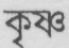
কৃষ্ণ
